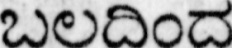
ಬಲದಿಂದ
